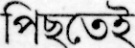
পিছতেই
